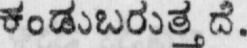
ಕಂಡುಬರುತ್ತದೆ.
